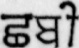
ਛਬੀ
